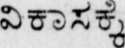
ವಿಕಾಸಕ್ಕೆ
